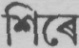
শিৰে
